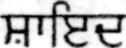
ਸ਼ਾਇਦ
